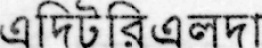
এদিটরিএলদা
